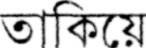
তাকিয়ে
